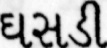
ઘસડી
